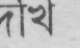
দখি
